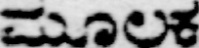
ಮೂಲಕ
